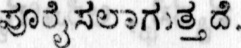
ಪೂರೈಸಲಾಗುತ್ತದೆ.
